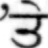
'ਤੇ
